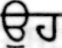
ਉਹ
